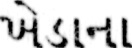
ખેડાના
